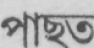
পাছত
